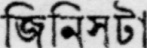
জিনিসটা
